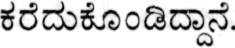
ಕರೆದುಕೊಂಡಿದ್ದಾನೆ.
